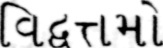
વિદ્ધત્તમો
